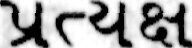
પ્રત્યક્ષ
